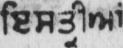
ਇਸਤ੍ਰੀਆਂ
